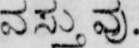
ವಸ್ತುವು.
